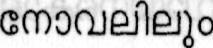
നോവലിലും
